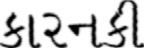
કારનકી
